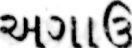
અગાઉ
